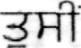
ਤੁਸੀਂ
